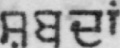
ਸ਼ਬਦਾਂ
